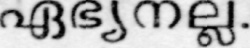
ഏഭ്യനല്ല.
